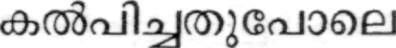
കല്‍പിച്ചതുപോലെ
